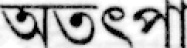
অতৎপা
